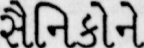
સૈનિકોને
